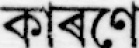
কাৰণে
